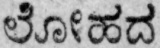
ಲೋಹದ
